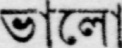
ভালো
